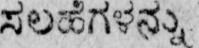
ಸಲಹೆಗಳನ್ನು
